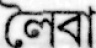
লৈবা
